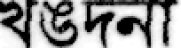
খঙদনা
